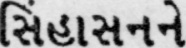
સિંહાસનને
